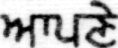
ਆਪਣੇ
